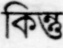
কিন্তু
